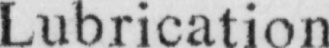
Lubrication
